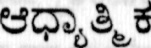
ಆಧ್ಯಾತ್ಮಿಕ
